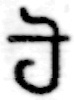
ਹੋ
